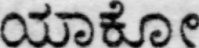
ಯಾಕೋ
